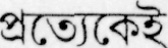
প্রত্যেকেই
